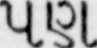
પણ
